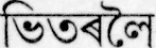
ভিতৰলৈ
